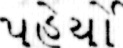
પહેર્યો
